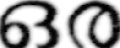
ഒര
